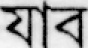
যাব
